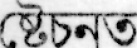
ষ্টেচনত
